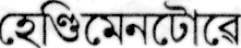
হেণ্ডিমেনটোৱে
